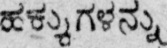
ಹಕ್ಕುಗಳನ್ನು
